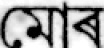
মোৰ
